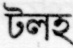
টলহ
